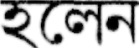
হলেন
